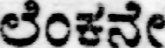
ಲೆಂಕನೇ
